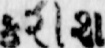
કરીશ
